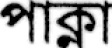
পাক্না
